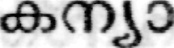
കന്യാ
